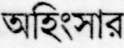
অহিংসার
